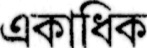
একাধিক
